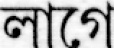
লাগে
